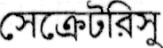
সেক্রেটরিসু
